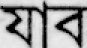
যাব
